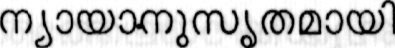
ന്യായാനുസൃതമായി
